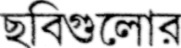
ছবিগুলোর
